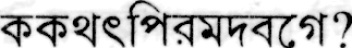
ককথৎপিরমদবগে?
